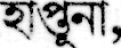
হাপ্তুনা,
